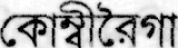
কোম্বীরৈগা
